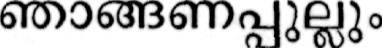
ഞാങ്ങണപ്പുല്ലും
